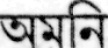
অমনি
